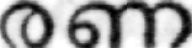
രണ
